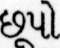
છૂપો
